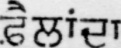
ਫ਼ੈਲਾਂਦਾ
